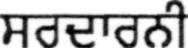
ਸਰਦਾਰਨੀ
